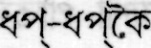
ধপ্‌-ধপ‌্কৈ
